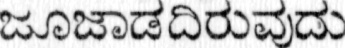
ಜೂಜಾಡದಿರುವುದು
